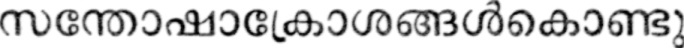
സന്തോഷാക്രോശങ്ങള്‍കൊണ്ടു
